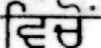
ਵਿਚੋਂ
